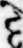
દે
